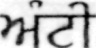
ਅੰਟੀ
